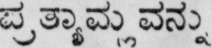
ಪ್ರತ್ಯಾಮ್ಲವನ್ನು
